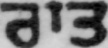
ਰਾਤ
